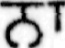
ਨਾ
